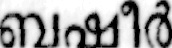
ബഷീര്‍
